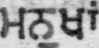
ਮਨੁਖਾਂ
